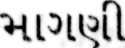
માગણી
